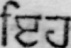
ਇਹ
